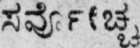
ಸರ್ವೋಚ್ಚ
